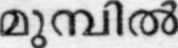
മുമ്പില്‍
